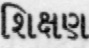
શિક્ષણ
